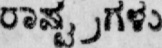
ರಾಷ್ಟ್ರಗಳು
